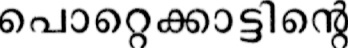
പൊറ്റെക്കാട്ടിന്റെ
